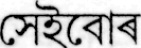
সেইবোৰ
